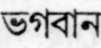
ভগবান
